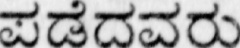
ಪಡೆದವರು
